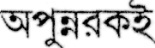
অপুন্নরকই
